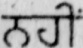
ਨਹੀਂ
